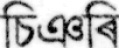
চিঞৰি
